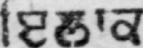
ਇਲਾਕ
